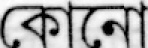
কোনো
